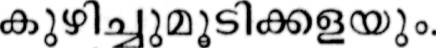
കുഴിച്ചുമൂടിക്കളയും.
